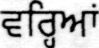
ਵਰ੍ਹਿਆਂ
